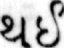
થઈ
